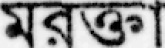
মরক্তা
